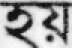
হয়
